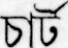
চাৰ্ট
